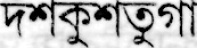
দশকুশতুগা
